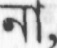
না,
